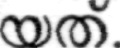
യത്.
